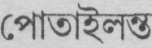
পোতাইলন্ত
